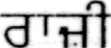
ਰਾਜ਼ੀ
